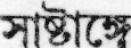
সাষ্টাঙ্গে
